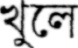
খুলে
